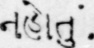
નહોતું.
